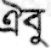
ঐবু
